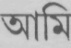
আমি
